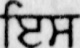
ਇਸ
